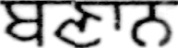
ਬਣਾਨ
